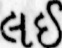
લઈ
